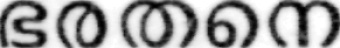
ഭരതനെ
